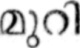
മുറി
